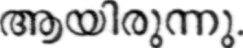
ആയിരുന്നു.
